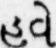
હવે
